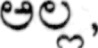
ಅಲ್ಲ,
